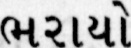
ભરાયો
